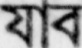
যাব
